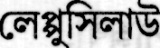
লেপ্পুসিলাউ
